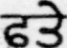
ਫਤੇ
